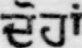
ਦੋਹਾਂ
